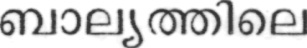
ബാല്യത്തിലെ
